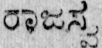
ರಾಜಸ್ವ
